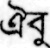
ঐবু
